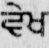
ਵੇਖ
